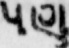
પણ
